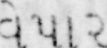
વેપાર
